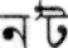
ন'ট
